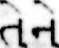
તેને
